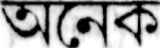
অনেক
